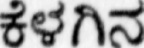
ಕೆಳಗಿನ
